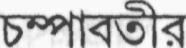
চম্পাবতীর
